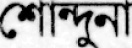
শোন্দুনা
